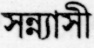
সন্ন্যাসী
